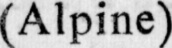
(Alpine)
